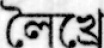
লৈখ্রে
